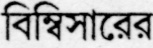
বিম্বিসারের
